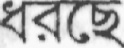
ধরছে
